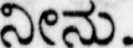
ನೀನು.
